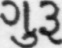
ગુરુ
